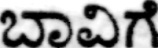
ಬಾವಿಗೆ
